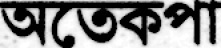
অতেকপা
